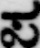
ಪ
